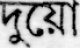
দুয়ো
